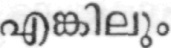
എങ്കിലും
